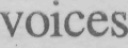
voices
